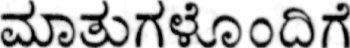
ಮಾತುಗಳೊಂದಿಗೆ
